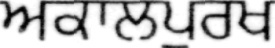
ਅਕਾਲਪੁਰਖ
